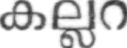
കല്ലറ
